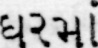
ઘરમાં
